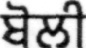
ਬੋਲੀ
